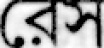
রেস
